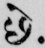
છે.
